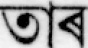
তাৰ
